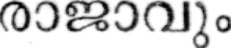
രാജാവും
